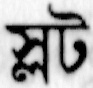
স্লট
